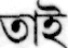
তাই
